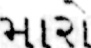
મારો
